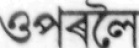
ওপৰলৈ
